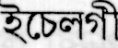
ইচেলগী
